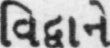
વિદ્વાને
